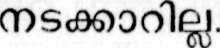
നടക്കാറില്ല.
